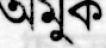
অমুক
